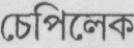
চেপিলেক
